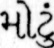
મોટું
